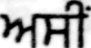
ਅਸੀਂ
